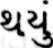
થયું
